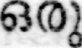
ഒരു
